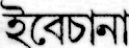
ইবেচানা
